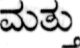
ಮತ್ತು
